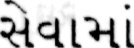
સેવામાં
